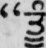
''ਤੂੰ
